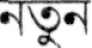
নতুন
